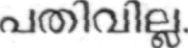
പതിവില്ല.
